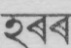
হৰৰ
